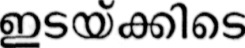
ഇടയ്ക്കിടെ
